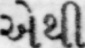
એથી
